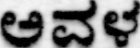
ಅವಳ
